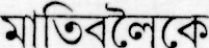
মাতিবলৈকে
